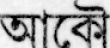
আকৌ
